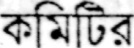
কমিটির
